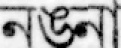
নঙনা
